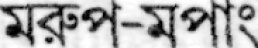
মরুপ-মপাং
